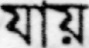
যায়
